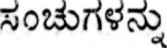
ಸಂಚುಗಳನ್ನು
